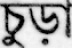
চুড়া
